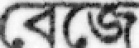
বেজে
